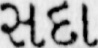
સદા
